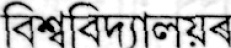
বিশ্ববিদ্যালয়ৰ
